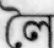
লৈ
